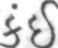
કંઈ
